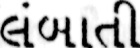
લંબાતી
